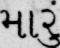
મારું
